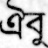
ঐবু
